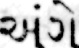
અંગે
